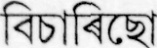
বিচাৰিছো
